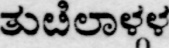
ತುೞಿಲಾಳ್ಗಳ
